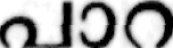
പാറ
